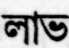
লাভ
